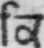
ਕਿ
